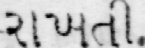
રાખતી.
